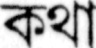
কথা
